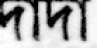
দাদা
